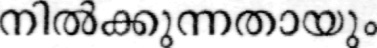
നില്‍ക്കുന്നതായും
